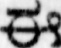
ಈ
